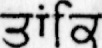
ਤਾਂਕਿ
